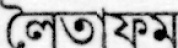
লৈতাফম
